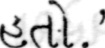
હતો.'
